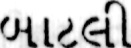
બાટલી
